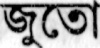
জুতো
